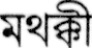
মথক্কী
